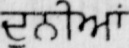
ਦੁਨੀਆਂ
